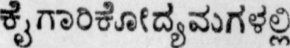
ಕೈಗಾರಿಕೋದ್ಯಮಗಳಲ್ಲಿ
